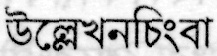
উল্লেখনচিংবা
